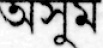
অসুম
